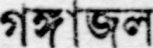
গঙ্গাজল
